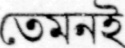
তেমনই
